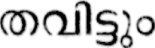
തവിട്ടും
